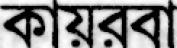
কায়রবা
